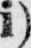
i)
